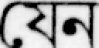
যেন
